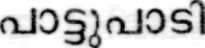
പാട്ടുപാടി
